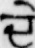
ਦੇ
